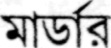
মার্ডার
